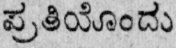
ಪ್ರತಿಯೊಂದು
